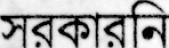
সরকারনি
